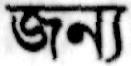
জন্য
